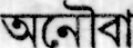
অনৌবা
